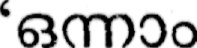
'ഒന്നാം
